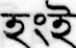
হংই
